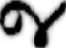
જ
